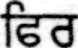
ਫਿਰ
